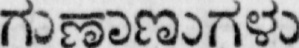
ಗುಣಾಣುಗಳು
